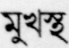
মুখস্থ
